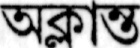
অক্লান্ত
